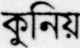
কুনিয়
